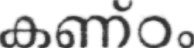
കണ്ഠം
